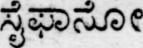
ಸೈಫಾನೋ
